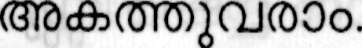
അകത്തുവരാം.
